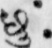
છું.
